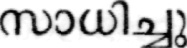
സാധിച്ചു
